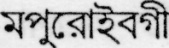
মপুরোইবগী
